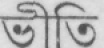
ভীতি
